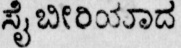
ಸೈಬೀರಿಯಾದ
